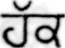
ਹੱਕ
